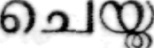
ചെയ്ത
